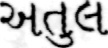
અતુલ
